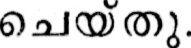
ചെയ്തു.
